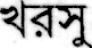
খরসু
